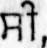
ਸੀ,
